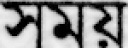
সময়
